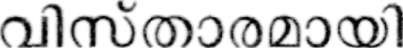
വിസ്താരമായി
